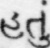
હતું
